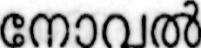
നോവല്‍
